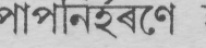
পাপনিৰ্হৰণে
